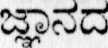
ಜ್ಞಾನದ
